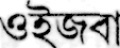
ওইজবা
